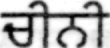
ਚੀਨੀ
